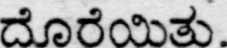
ದೊರೆಯಿತು.
